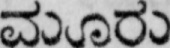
ಮೂರು
